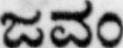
ಜವಂ
